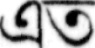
এত
